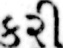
કરી
